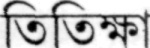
তিতিক্ষা
